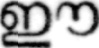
ഈ
